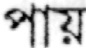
পায়
